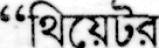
“থিয়েটর
